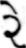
રે
